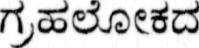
ಗ್ರಹಲೋಕದ
